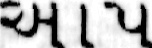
આપ
